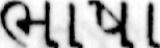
ભાષા
